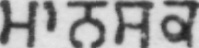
ਮਾਨਸਕ
